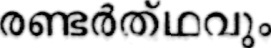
രണ്ടര്‍ത്ഥവും
